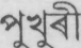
পুখুৰী
